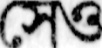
সেও
